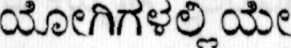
ಯೋಗಿಗಳಲ್ಲಿಯೇ
